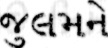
જુલમને
